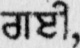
ਗਈ,
